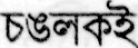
চঙলকই
